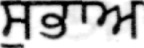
ਸੁਭਾਅ
